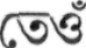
তেওঁ
